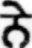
ਨੇ
